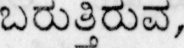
ಬರುತ್ತಿರುವ,
